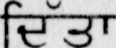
ਦਿੱਤਾ
